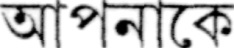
আপনাকে
